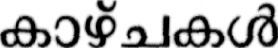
കാഴ്ചകള്‍
